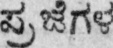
ಪ್ರಜೆಗಳ
